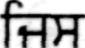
ਜਿਸ
